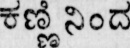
ಕಣ್ಣಿನಿಂದ
